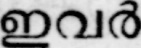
ഇവര്‍
